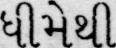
ધીમેથી
